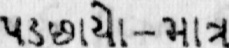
પડછાયો-માત્ર
